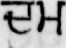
ਦਮ
